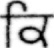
ਕਿ
